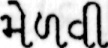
મેળવી
